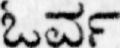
ಓರ್ವ
